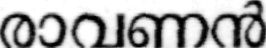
രാവണന്‍
